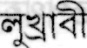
লুখ্রাবী
